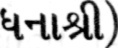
ધનાશ્રી)
